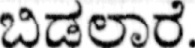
ಬಿಡಲಾರೆ.
